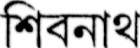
শিবনাথ
